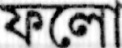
ফলো
